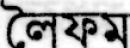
লৈফম
